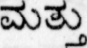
ಮತ್ತು
